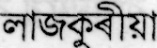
লাজকুৰীয়া
